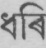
ধৰি
